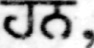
ਹਨ,
